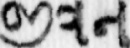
જીવન
